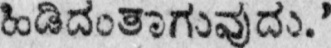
ಹಿಡಿದಂತಾಗುವುದು.’
